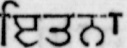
ਇਤਨਾ
